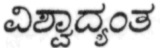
ವಿಶ್ವಾದ್ಯಂತ
